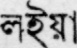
লইয়া
